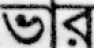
ভার
